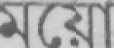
ময়ো
